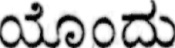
ಯೊಂದು
